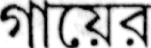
গায়ের
